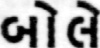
બોલે
